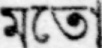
মতো
